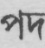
পদ
